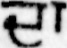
ਦਾ
